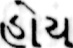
હોય
